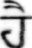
ਹੈ
